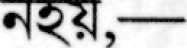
নহয়,-
